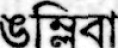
ঙম্লিবা
